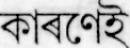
কাৰণেই
